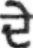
ਦੇ
